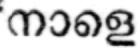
‘നാളെ
